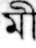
মী
